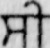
ਸੀ
